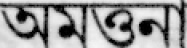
অমত্তনা
